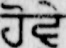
ਹੋਵੇ
